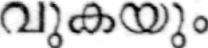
വുകയും
